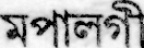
মপালগী
